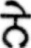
ਨੇ
